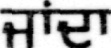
ਜਾਂਦਾ
